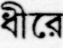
ধীরে
